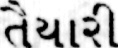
તૈયારી
